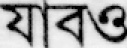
যাবও
